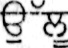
ਉੱਲੂ
